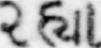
રહ્યા
